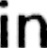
in
